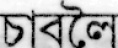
চাবলৈ
